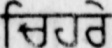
ਚਿਹਰੇ
